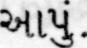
આપું.
